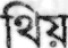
থিয়
